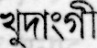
খুদাংগী
